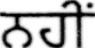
ਨਹੀਂ
